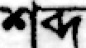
শব্দ
